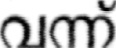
വന്ന്
